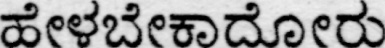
ಹೇಳಬೇಕಾದೋರು
